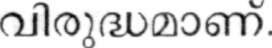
വിരുദ്ധമാണ്.
